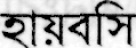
হায়বসি
